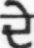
ਦੇ
